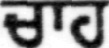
ਚਾਹ
